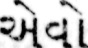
એવો
